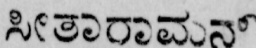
ಸೀತಾರಾಮನ್
